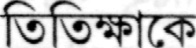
তিতিক্ষাকে
